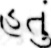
હતું
